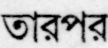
তারপর
